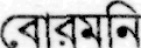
বোরমনি
